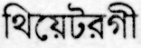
থিয়েটরগী
